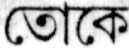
তোকে
